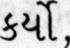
કર્યો,
